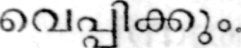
വെപ്പിക്കും.
